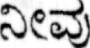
ನೀವು
